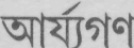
আৰ্য্যগণ
